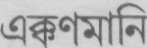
এক্কণমানি
